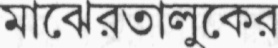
মাঝেরতালুকের
